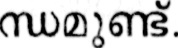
ന്ധമുണ്ട്.
